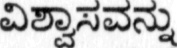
ವಿಶ್ವಾಸವನ್ನು
